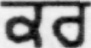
ਕਰ
